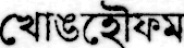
খোঙহৌফম
